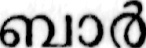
ബാര്‍
